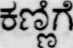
ಕಣ್ಣಿಗೆ
